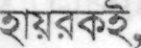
হায়রকই,
